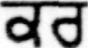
ਕਰ
